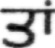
ਤਾਂ
